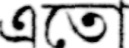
এতো
